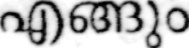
എങ്ങും
